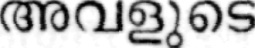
അവളുടെ
